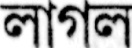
লাগল
